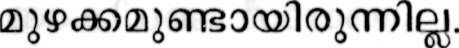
മുഴക്കമുണ്ടായിരുന്നില്ല.
